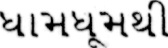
ધામધૂમથી
